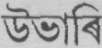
উভাৰি
